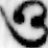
ও
